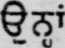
ਉਨ੍ਹਾਂ
